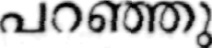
പറഞ്ഞു
